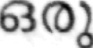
ഒരു
